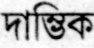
দাম্ভিক
